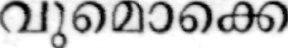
വുമൊക്കെ
